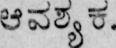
ಆವಶ್ಯಕ,
